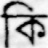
কি
